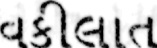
વકીલાત
